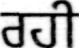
ਰਹੀ
